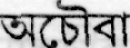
অচৌবা
